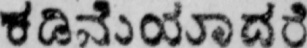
ಕಡಿಮೆಯಾದರೆ
